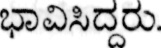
ಭಾವಿಸಿದ್ದರು.
